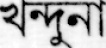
খন্দুনা
